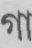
গা
